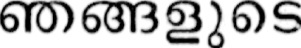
ഞങ്ങളുടെ
